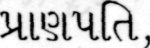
પ્રાણપતિ,
